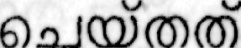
ചെയ്തത്
